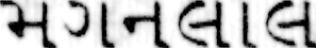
મગનલાલ
